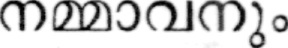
നമ്മാവനും
